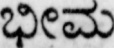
ಭೀಮ
